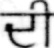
ਦੀ
